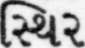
સ્થિર
